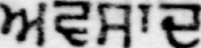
ਅਵਸਾਦ
